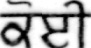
ਕੋਈ
